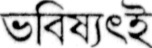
ভবিষ্যৎই
